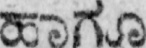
ಹಾಗೂ
